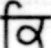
ਕਿ
